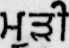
ਮੁੜੀ
